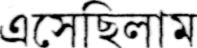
এসেছিলাম
